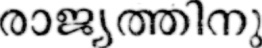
രാജ്യത്തിനു
